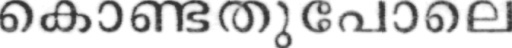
കൊണ്ടതുപോലെ
